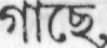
গাছে,
